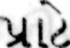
પ્રાટે
